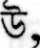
উ,
